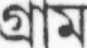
গ্রাম
